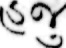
હજું
